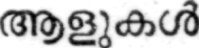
ആളുകള്‍
